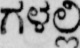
ಗಳಲ್ಲಿ
